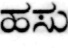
ಹಸು
